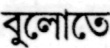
বুলোতে
